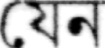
যেন
